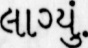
લાગ્યું.
